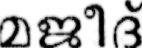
മജീദ്
